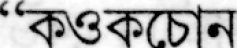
"কওকচোন
